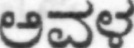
ಅವಳ
